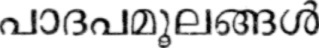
പാദപമൂലങ്ങള്‍
